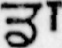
ਡਾ
